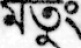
মতুং
